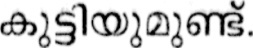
കുട്ടിയുമുണ്ട്.
